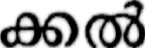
ക്കല്‍
